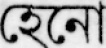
হেনো
